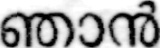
ഞാന്‍
